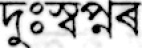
দুঃস্বপ্নৰ
